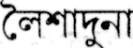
লৈশাদুনা
